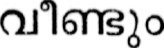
വീണ്ടും
